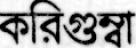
করিগুম্বা
